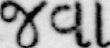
જવા
